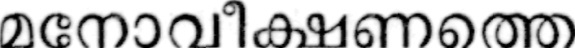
മനോവീക്ഷണത്തെ
